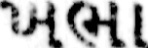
ખભા
